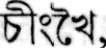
চীংখৈ,
